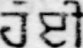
ਹੋਈ
